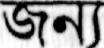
জন্য
